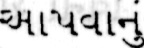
આપવાનું
